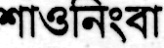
শাওনিংবা
